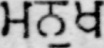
ਮਨੁਖ
